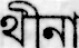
থীনা
